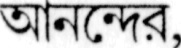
আনন্দের,
